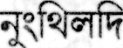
নুংথিলদি
